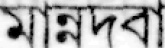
মান্নদবা
